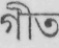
গীত
